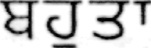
ਬਹੁਤਾ
